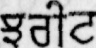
ਝਰੀਟ
